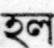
হল
